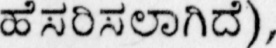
ಹೆಸರಿಸಲಾಗಿದೆ),
